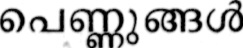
പെണ്ണുങ്ങള്‍
